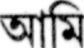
আমি
